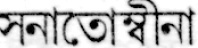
সনাতোম্বীনা
